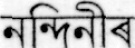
নন্দিনীৰ
